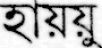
হায়য়ু
